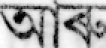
আৰু
